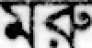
মরু
